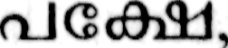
പക്ഷേ,
